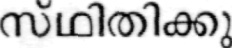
സ്ഥിതിക്കു
